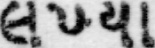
લખ્યા
